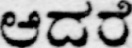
ಆದರೆ
